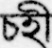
চহী
